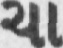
ચા
